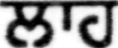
ਲਾਹ
